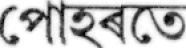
পোহৰতে
